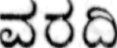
ವರದಿ
